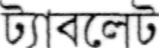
ট্যাবলেট
